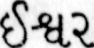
ઈશ્વર
